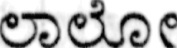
ಲಾಲೋ
